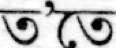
ত'তে
